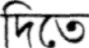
দিতে
